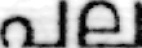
പല
